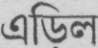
এড়িল
